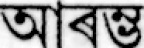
আৰম্ভ
